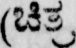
(ಚಿತ್ರ
